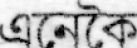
এনেকৈ
